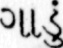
ગાડું
